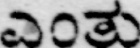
ಎಂತು
